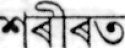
শৰীৰত
